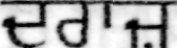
ਦਰਾਜ਼
